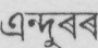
এন্দুৰৰ
